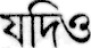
যদিও
